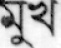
মুখ
